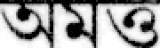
অমত্ত
